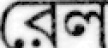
রেল
